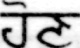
ਹੋਣ
